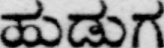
ಹುಡುಗ
